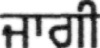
ਜਾਗੀ
